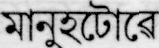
মানুহটোৱে
